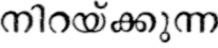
നിറയ്ക്കുന്ന
